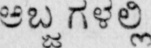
ಅಬ್ಜಗಳಲ್ಲಿ
